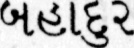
બહાદુર
